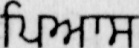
ਪਿਆਸ
